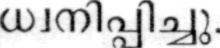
ധ്വനിപ്പിച്ചു.
